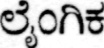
ಲೈಂಗಿಕ
